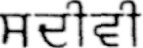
ਸਦੀਵੀ
